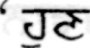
'ਹੁਣ
